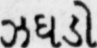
ઝઘડો
